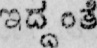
ಇದ್ದಂತೆ
